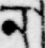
না
